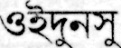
ওইদুনসু
